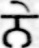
ਨੇ
